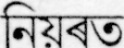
নিয়ৰত
